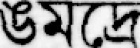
ঙমদ্রে
